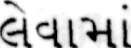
લેવામાં
